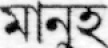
মানুহ
